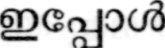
ഇപ്പോള്‍
